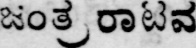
ಜಂತ್ರರಾಟವ
